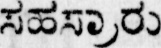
ಸಹಸ್ರಾರು
